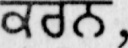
ਕਰਨ,
